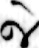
જે
